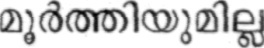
മൂര്‍ത്തിയുമില്ല
